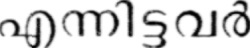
എന്നിട്ടവര്‍
